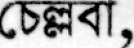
চেল্লবা,
